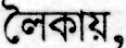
লৈকায়,
